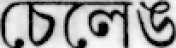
চেলেঙ
